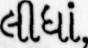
લીધાં,
